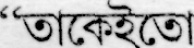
"তাকেইতো
